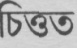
চিত্তত
